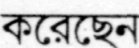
করেছেন
